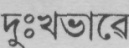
দুঃখভাৱে
